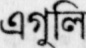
এগুলি
